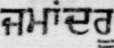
ਜਮਾਂਦਰੂ
